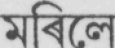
মৰিলে
